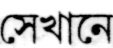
সেখানে
